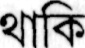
থাকি
